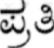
ಪ್ರತಿ
